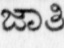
ಜಾತಿ
